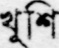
খুশি
